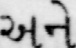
અને
